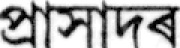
প্রাসাদৰ
